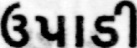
ઉપાડી
